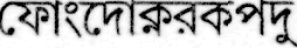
ফোংদোক্নরকপদু
